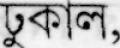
ঢুকাল,
